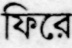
ফিরে
